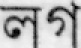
লগ
